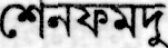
শেনফমদু
